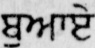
ਬੁਆਏ
